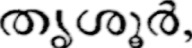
തൃശൂര്‍,
